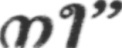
നീ"
